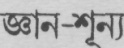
জ্ঞান-শূন্য
